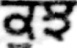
ਕੁਝ
